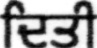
ਦਿਤੀ
